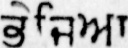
ਭੇਜਿਆ
